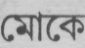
মোকে
